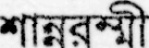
শান্নরম্মী
